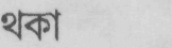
থকা
